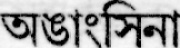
অঙাংসিনা
